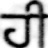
ਹੀ
